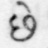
છે
